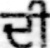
ਦੀ
